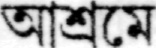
আশ্রমে
